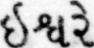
ઈશ્ર્વરે
